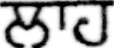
ਲਾਹ
